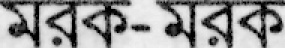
মরক-মরক
